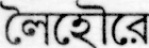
লৈহৌরে
